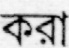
করা
